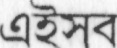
এইসব
